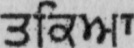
ਤਕਿਆ
